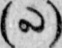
(ಎ)
